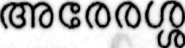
അരേരശ്ശ
